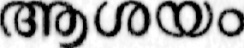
ആശയം
